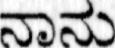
ನಾನು
